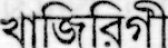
খাজিরিগী
